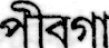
পীবগা
